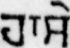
ਹਾਸੇ
